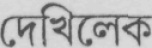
দেখিলেক
